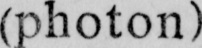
(photon)
